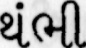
થંભી
